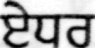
ਏਧਰ
